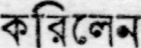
করিলেন
